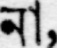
না,
